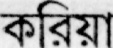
করিয়া
